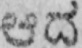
ಆದ
